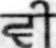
ਵੀ
